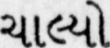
ચાલ્યો
